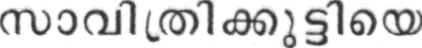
സാവിത്രിക്കുട്ടിയെ
